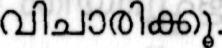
വിചാരിക്കൂ.
